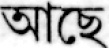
আছে
